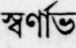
স্বর্ণাভ
